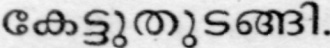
കേട്ടുതുടങ്ങി.
